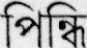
পিন্ধি
